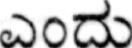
ಎಂದು
